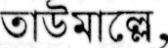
তাউমাল্লে,
